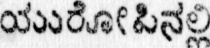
ಯುರೋಪಿನಲ್ಲಿ
